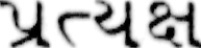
પ્રત્યક્ષ
